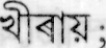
খীৰায়;
